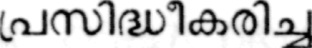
പ്രസിദ്ധീകരിച്ച
